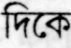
দিকে
